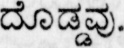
ದೊಡ್ಡವು.
